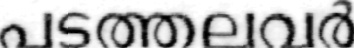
പടത്തലവര്‍
